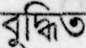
বুদ্ধিত
